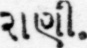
રાણી.
